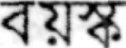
বয়স্ক
